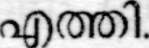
എത്തി.
